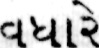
વધારે
